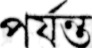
পর্যন্ত
